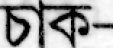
চাক-
